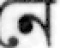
নে
